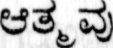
ಆತ್ಮವು
